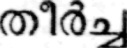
തീര്‍ച്ച
